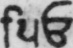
ਪਿਓ
